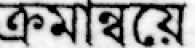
ক্রমান্বয়ে
